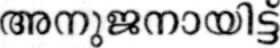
അനുജനായിട്ട്
